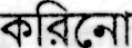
করিনো
